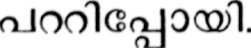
പററിപ്പോയി.
